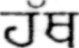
ਹੱਥ
